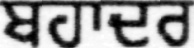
ਬਹਾਦਰ
